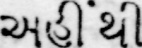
અહીંથી
